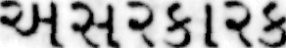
અસરકારક
